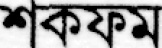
শকফম
